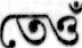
তেওঁ
